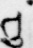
તું
